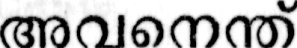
അവനെന്ത്
